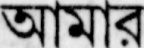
আমার
